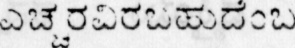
ಎಚ್ಚರವಿರಬಹುದೆಂಬ
